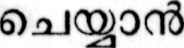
ചെയ്യാന്‍
